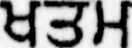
ਖਤਮ
